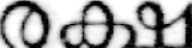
രക്ഷ
